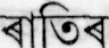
ৰাতিৰ
